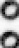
ঃ
